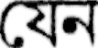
যেন
